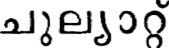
ചുല്യാറ്റ്
